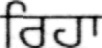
ਰਿਹਾ
